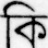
কি
